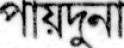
পায়দুনা
